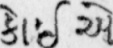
કોઈએ
